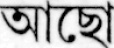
আছো
